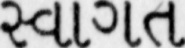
સ્વાગત
